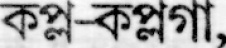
কপ্ল-কপ্লগা,
